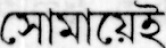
সোমায়েই
